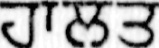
ਹਾਲਤ
